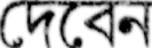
দেবেন
